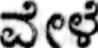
ವೇಳೆ
